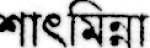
শাৎমিন্না
